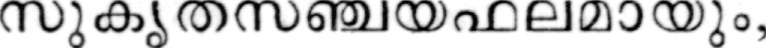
സുകൃതസഞ്ചയഫലമായും,
